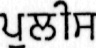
ਪੁਲੀਸ
